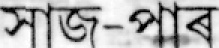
সাজ-পাৰ
